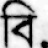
বি.
